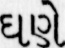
ઘણે
